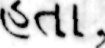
હતા,
